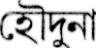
হৌদুনা
